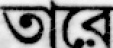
তারে
